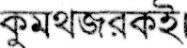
কুমথজরকই।
